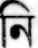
নি
